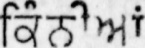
ਕਿੰਨੀਆਂ
